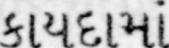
કાયદામાં
